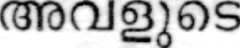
അവളുടെ
